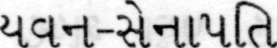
યવન-સેનાપતિ
